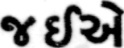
જઈએ
